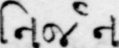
નિર્જન
